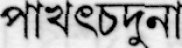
পাখৎচদুনা
